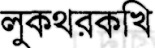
লুকথরকখি
